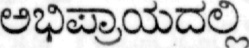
ಅಭಿಪ್ರಾಯದಲ್ಲಿ
